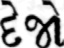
દેજો
